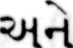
અને
